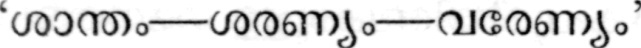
'ശാന്തം-ശരണ്യം-വരേണ്യം'
